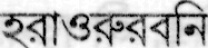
হরাওরুরবনি
